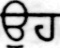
ਉਹ
